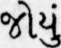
જોયું
